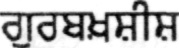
ਗੁਰਬਖ਼ਸ਼ੀਸ਼
